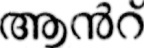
ആന്റ്
